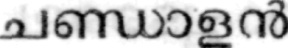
ചണ്ഡാളന്‍
